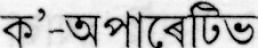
ক'-অপাৰেটিভ
